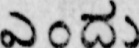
ಎಂದು
